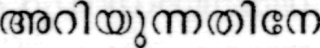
അറിയുന്നതിനേ
